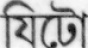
যিটো
